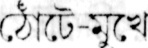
ঠোঁটে-মুখে
